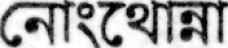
নোংথোন্না
